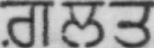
ਗ਼ਲਤ
